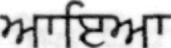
ਆਇਆ
